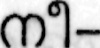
നീ-
